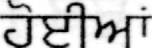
ਹੋਈਆਂ
